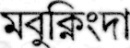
মবুক্নিংদা
